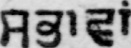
ਸਭਾਵਾਂ
